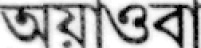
অয়াওবা
